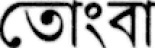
তোংবা
